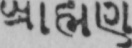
બ્રાહ્મણ
